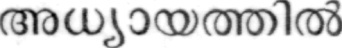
അധ്യായത്തില്‍
